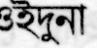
ওইদুনা
